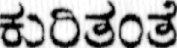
ಕುರಿತಂತೆ
